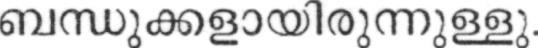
ബന്ധുക്കളായിരുന്നുള്ളു.
